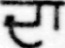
ਦਾ
